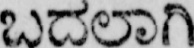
ಬದಲಾಗಿ
